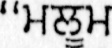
''ਮਲੂਮ
